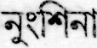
নুংশিনা
